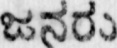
ಜನರು
